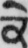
ਕੇ
